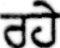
ਰਹੇ
